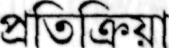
প্রতিক্রিয়া
